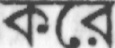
করে
